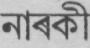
নাৰকী
